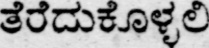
ತೆರೆದುಕೊಳ್ಳಲಿ
